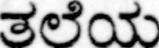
ತಲೆಯ
